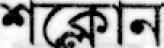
শক্লোন
